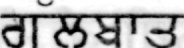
ਗੱਲਬਾਤ
